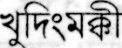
খুদিংমক্কী
